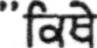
''ਕਿਥੇ
